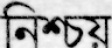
নিশ্চয়
